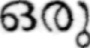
ഒരു
